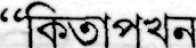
"কিতাপখন
